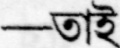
–তাই
